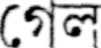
গেল
